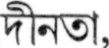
দীনতা,
